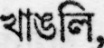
খাঙলি,
